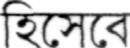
হিসেবে
